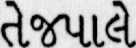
તેજપાલે
